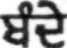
ਬੰਦੇ
